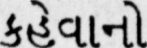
કહેવાનો
